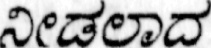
ನೀಡಲಾದ
